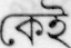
কেই
